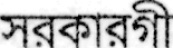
সরকারগী
